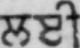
ਲਈ
